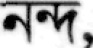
নন্দ,
